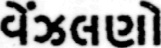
વેંઝલણો
